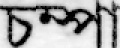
চম্পা
